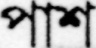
পাশ
